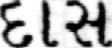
દાસ
